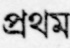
প্রথম
